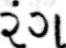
રંગ
